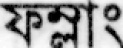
ফম্লাং
